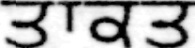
ਤਾਕਤ
